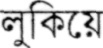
লুকিয়ে
